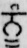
ਨੂੰ
